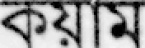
কয়াম
